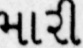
મારી
